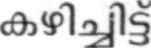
കഴിച്ചിട്ട്
